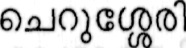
ചെറുശ്ശേരി
